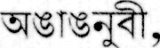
অঙাঙনুবী,
